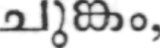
ചുങ്കം,
